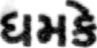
ધમકે
